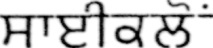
ਸਾਈਕਲੋਂ
